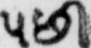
પછી
